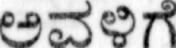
ಅವಳಿಗೆ
